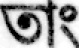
তাং
